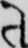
તે
